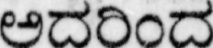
ಅದರಿಂದ
